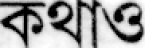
কথাও
